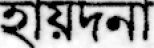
হায়দনা
